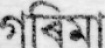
গৰিমা
